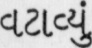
વટાવ્યું
